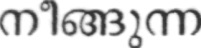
നീങ്ങുന്ന
